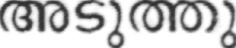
അടുത്തു
